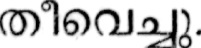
തീവെച്ചു.
